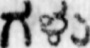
ಗಳು
